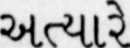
અત્યારે
